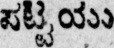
ಪಟ್ಟಿಯು
